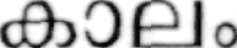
കാലം
